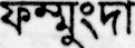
ফম্মুংদা
